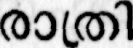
രാത്രി
